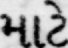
માટે
